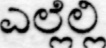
ಎಲ್ಲೆಲ್ಲಿ
